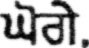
ਘੋਗੇ,
